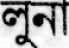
লুনা
